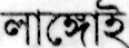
লাঙ্গোই
